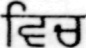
ਵਿਚ
